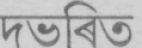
দেভৰিত
